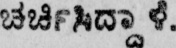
ಚರ್ಚಿಸಿದ್ದಾಳೆ.
